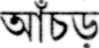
আঁচড়
